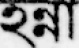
হন্না
